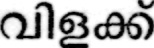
വിളക്ക്
